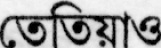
তেতিয়াও
